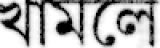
খামলে
